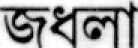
জধলা
